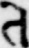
'તે
